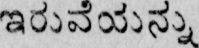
ಇರುವೆಯನ್ನು
